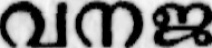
വനജ
